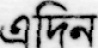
এদিন
